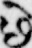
છે
